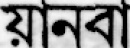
য়ানবা
